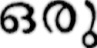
ഒരു
